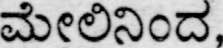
ಮೇಲಿನಿಂದ,
